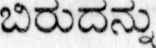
ಬಿರುದನ್ನು
